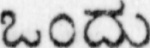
ಒಂದು
